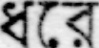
ধরে
